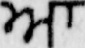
ਆ
